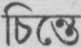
চিন্তে
